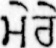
ਮੇਰੇ
